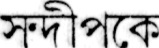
সন্দীপকে
